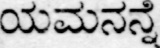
ಯಮನನ್ನೆ
